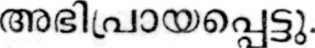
അഭിപ്രായപ്പെട്ടു.
